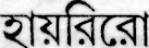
হায়রিবো
